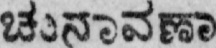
ಚುನಾವಣಾ
